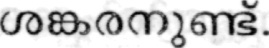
ശങ്കരനുണ്ട്.
